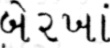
બેરખાં
